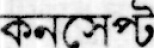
কনসেপ্ট
